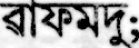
ৱাফমদু;
